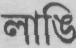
লাঙি
